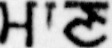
ਮਾਣ
